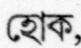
হোক,
